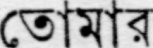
তোমার
